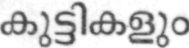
കുട്ടികളും
